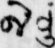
જેવું
